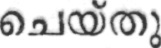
ചെയ്തു
